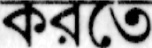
করতে
